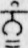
ਨੂੰ
